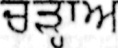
ਚੜ੍ਹਾਅ
